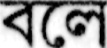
বলে
